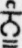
ਨੂੰ
